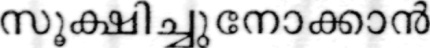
സൂക്ഷിച്ചുനോക്കാന്‍
